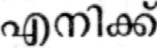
എനിക്ക്
